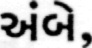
અંબે,
